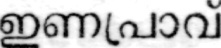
ഇണപ്രാവ്
